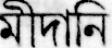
মীদানি
